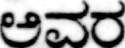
ಅವರ
